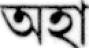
অহা
